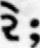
રે;
